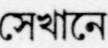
সেখানে
